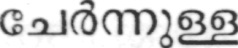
ചേര്‍ന്നുള്ള
